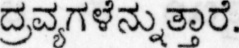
ದ್ರವ್ಯಗಳೆನ್ನುತ್ತಾರೆ.
